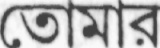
তোমার
